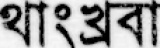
থাংখ্রবা
